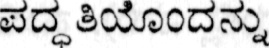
ಪದ್ಧತಿಯೊಂದನ್ನು
